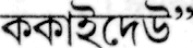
ককাইদেউ"
